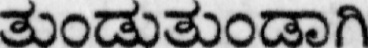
ತುಂಡುತುಂಡಾಗಿ
